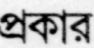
প্রকার
